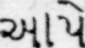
આપે
